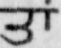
ਤਾਂ
